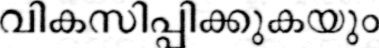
വികസിപ്പിക്കുകയും
